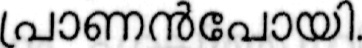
പ്രാണന്‍പോയി.
